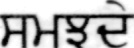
ਸਮਝਦੇ
